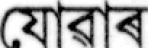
যোৱাৰ
